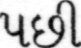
પછી
